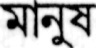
মানুষ
